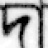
দা
